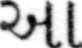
આ
